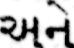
અને
